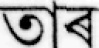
তাৰ
